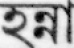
হন্না
